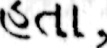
હતા,
